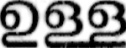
ഉള്ള
